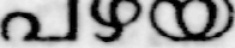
പഴയ
